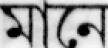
মানে
